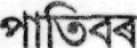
পাতিবৰ
